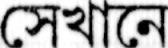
সেখানে
